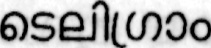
ടെലിഗ്രാം
